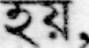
হয়,
